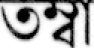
তম্বা
